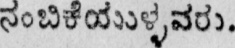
ನಂಬಿಕೆಯುಳ್ಳವರು.
